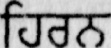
ਹਿਰਨ
